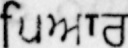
ਪਿਆਰ
